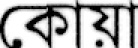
কোয়া
